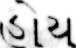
હોય
